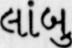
લાંબુ
